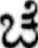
ಚೆ
